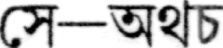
সে–অথচ
